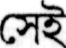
সেই
